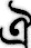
ঐ
